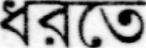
ধরতে
